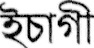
ইচাগী
